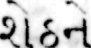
શેઠને
